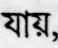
যায়,
